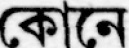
কোনে
